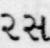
રસ
